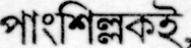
পাংশিল্লকই,
